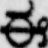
ಈ
